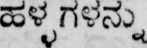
ಹಳ್ಳಗಳನ್ನು
